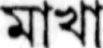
মাখা
